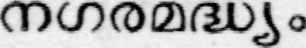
നഗരമദ്ധ്യം
